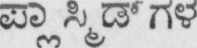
ಪ್ಲಾಸ್ಮಿಡ್‌ಗಳ
